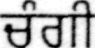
ਚੰਗੀ
